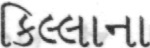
કિલ્લાના
